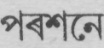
পৰশনে
